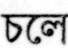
চলে
